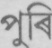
পুৰি
